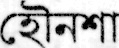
হৌনশা
